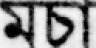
মচা
